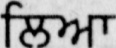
ਲਿਆ
